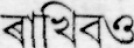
ৰাখিবও
